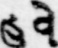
હવે
